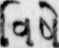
વિષે
